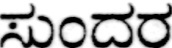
ಸುಂದರ
